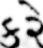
કરે
